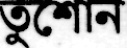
তুশোন
